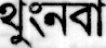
থুংনবা
